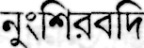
নুংশিরবদি
